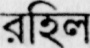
রহিল
